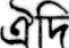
ঐদি
